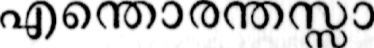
എന്തൊരന്തസ്സാ
